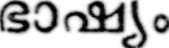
ഭാഷ്യം
